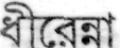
ধীরেন্না
